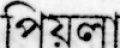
পিয়লা
